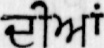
ਦੀਆਂ
